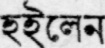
হইলেন
